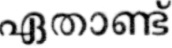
ഏതാണ്ട്
